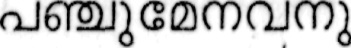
പഞ്ചുമേനവനു
